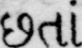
છતાં
